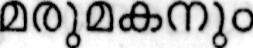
മരുമകനും
